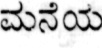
ಮನೆಯಿ
